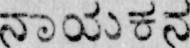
ನಾಯಕನ
